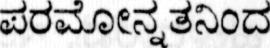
ಪರಮೋನ್ನತನಿಂದ
